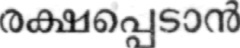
രക്ഷപ്പെടാന്‍
